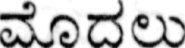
ಮೊದಲು
